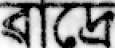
ৱাদ্রে
